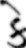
કે
